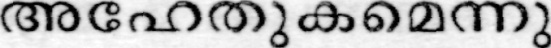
അഹേതുകമെന്നു
